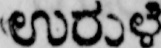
ಉರುಳೆ
